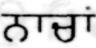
ਨਾਚਾਂ
